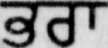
ਭਰਾ
